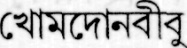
খোমদোনবীবু
